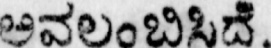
ಅವಲಂಬಿಸಿದೆ.
